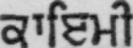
ਕਾਇਮੀ
